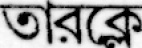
তারক্লে
